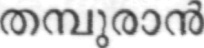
തമ്പുരാന്‍
